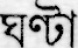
ঘণ্টা
